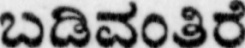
ಬಡಿವಂತಿರೆ
